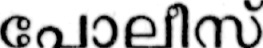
പോലീസ്
